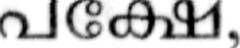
പക്ഷേ,
